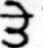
ਤੇ
